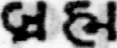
બ્રહ્મ
